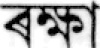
ৰক্ষা
